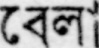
বেলা
